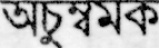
অচুম্বমক
